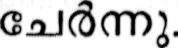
ചേര്‍ന്നു.
